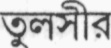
তুলসীর
